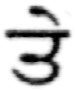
ਤੇ
